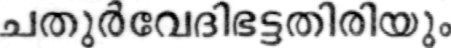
ചതുര്‍വേദിഭട്ടതിരിയും
